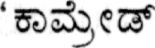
'ಕಾಮ್ರೇಡ್
